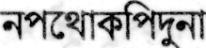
নপথোকপিদুনা
